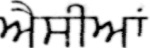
ਐਸੀਆਂ
